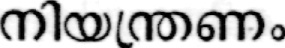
നിയന്ത്രണം
